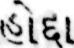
હોદ્દા
